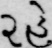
રહે
